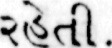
રહેતી.
